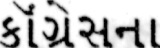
કૉંગ્રેસના
